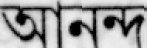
আনন্দ
